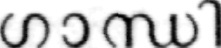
ഗാന്ധി
